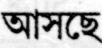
আসছে
